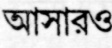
আসারও
